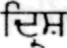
ਦ੍ਰਿਸ਼
